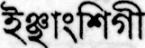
ইঞ্ছাংশিংগী
